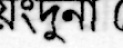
য়েংদুনা
